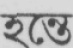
হন্তে
